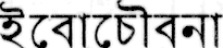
ইবোচৌবনা
